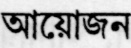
আয়োজন
